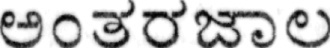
ಅಂತರಜಾಲ
